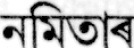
নমিতাৰ
